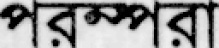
পরম্পরা
